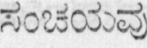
ಸಂಚಯವು
